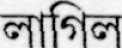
লাগিল
